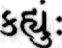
કહ્યું;
